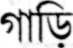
গাড়ি
